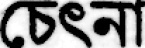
চেৎনা
